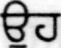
ਉਹ
